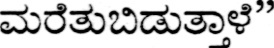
ಮರೆತುಬಿಡುತ್ತಾಳೆ"
